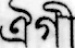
ঐগী
